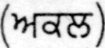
(ਅਕਲ)
